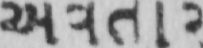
અવતાર
